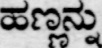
ಹಣ್ಣನ್ನು
